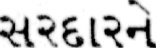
સરદારને
